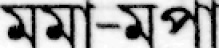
মমা-মপা
